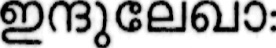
ഇന്ദുലേഖാ:
